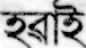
হৱাই
